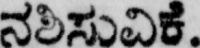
ನಶಿಸುವಿಕೆ.
